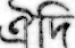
ঐদি
